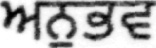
ਅਨੁਭਵ
